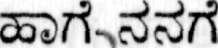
ಹಾಗೆನನಗೆ
